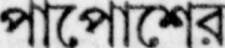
পাপোশের
